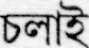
চলাই
